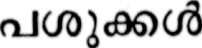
പശുക്കള്‍
